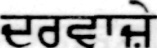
ਦਰਵਾਜ਼ੇ
